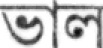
ভাল
